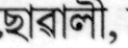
ছোৱালী,
